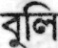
বুলি
